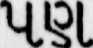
પણ
